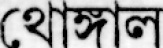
থোঙ্গাল
